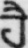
ਹੈ
